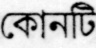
কোনটি
